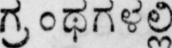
ಗ್ರಂಥಗಳಲ್ಲಿ
